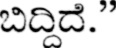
ಬಿದ್ದಿದೆ."
